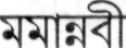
মমান্নবী
